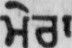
ਮੇਰਾ
